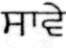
ਸਾਵੇ
